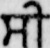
ਸੀ
